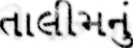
તાલીમનું
